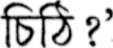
চিঠি?'
